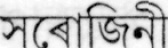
সৰোজিনী
